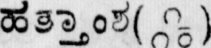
ಹತ್ತಾಂಶ(೧/೧೦)
